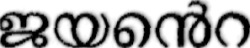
ജയന്റെ
